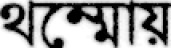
থম্মোয়
